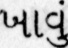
ખાવું
